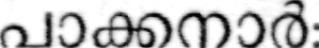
പാക്കനാര്‍:
